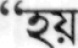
"হয়
